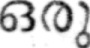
ഒരു
